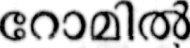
റോമില്‍
